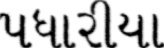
પધારીયા
